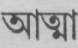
আত্মা
